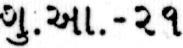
ગુ.આ.-૨૧.
